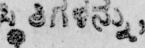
ಸ್ಥಿತಿಗಳನ್ನು,
